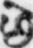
છે
